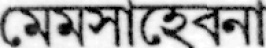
মেমসাহেবনা
